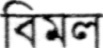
বিমল
